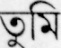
তুমি
